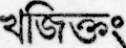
খজিক্তং
